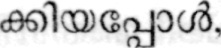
ക്കിയപ്പോള്‍,
